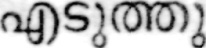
എടുത്തു
